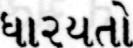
ધારયતો
